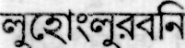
লুহোংলুরবনি
